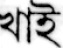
খাই
